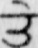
ਤੇ
